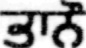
ਭਾਨੌ
